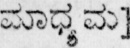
ಮಾಧ್ಯಮ]
